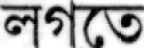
লগতে
